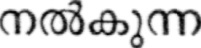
നല്‍കുന്ന
